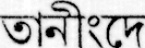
তানীংদে
